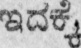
ಇದಕ್ಕೆ
